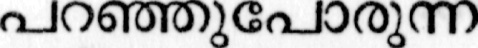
പറഞ്ഞുപോരുന്ന
